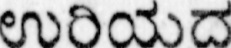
ಉರಿಯದ
